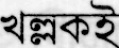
খল্লকই
